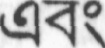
এবং
